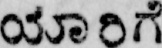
ಯಾರಿಗೆ
